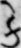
કે
